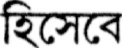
হিসেবে
